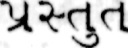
પ્રસ્તુત
